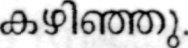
കഴിഞ്ഞു.
